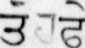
ਤੋਹਫੇ
